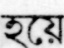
হয়ে
